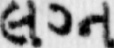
લગ્ન
